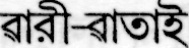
ৱারী-ৱাতাই
